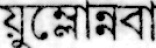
য়ুম্লোন্নবা
